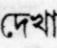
দেখা
